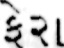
ફેરા
